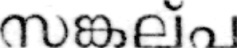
സങ്കല്പ
